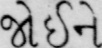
જોઈને
